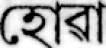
হোৱা
